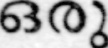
ഒരു
